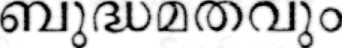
ബുദ്ധമതവും
